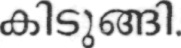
കിടുങ്ങി.
